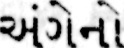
અંગેનો
